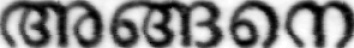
അങ്ങനെ
